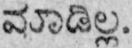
ಮಾಡಿಲ್ಲ.
